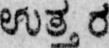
ಉತ್ತರ
